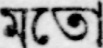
মতো
